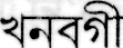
খনবগী
